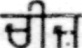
ਚੀਜ਼
